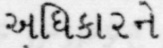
અધિકારને
